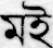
মই
